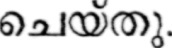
ചെയ്തു.
